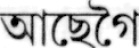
আছেগৈ
